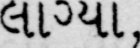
લાગ્યા,
